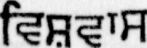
ਵਿਸ਼ਵਾਸ
